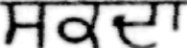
ਸਕਦਾ
